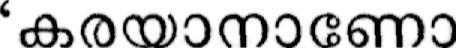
‘കരയാനാണോ
